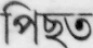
পিছত
